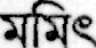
মমিৎ
